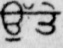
ਉੱਤੇ
